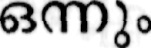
ഒന്നും
